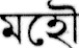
মহৌ
